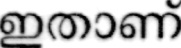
ഇതാണ്
